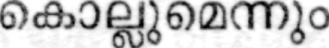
കൊല്ലുമെന്നും
